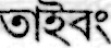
তাইবং
